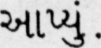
આપ્યું.
